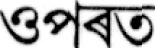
ওপৰত
